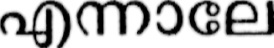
എന്നാലേ
